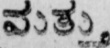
ಮತ್ತು
